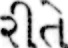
રીતે
